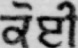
ਕੋਈ
